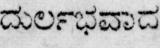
ದುರ್ಲಭವಾದ
